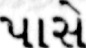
પાસે
